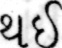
થઈ
